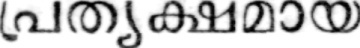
പ്രത്യക്ഷമായ
